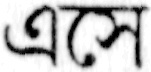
এসে
